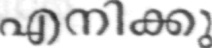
എനിക്കു
